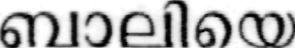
ബാലിയെ
